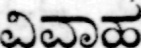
ವಿವಾಹ
